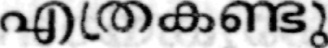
എത്രകണ്ടു
